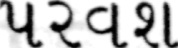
પરવશ
